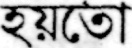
হয়তো
